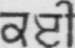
ਕਈ
